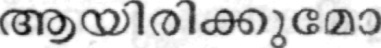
ആയിരിക്കുമോ
